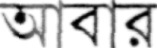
আবার
